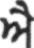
ਐ
